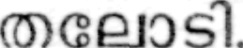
തലോടി.
